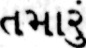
તમારું
